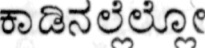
ಕಾಡಿನಲ್ಲೆಲ್ಲೋ
